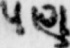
પણ
